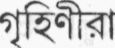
গৃহিণীরা
